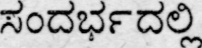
ಸಂದರ್ಭದಲ್ಲಿ
